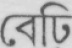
বেঢ়ি
